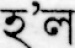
হ'ল
